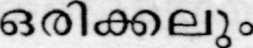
ഒരിക്കലും
